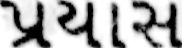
પ્રયાસ
